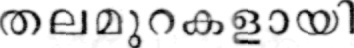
തലമുറകളായി
